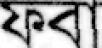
ফবা
